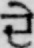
ਦੇ
